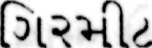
ગિરમીટ
